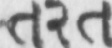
તરત
